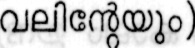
വലിന്റേയും)
